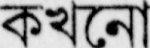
কখনো
